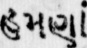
હમણાં
